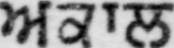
ਅਕਾਲ
